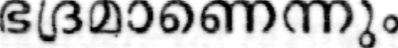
ഭദ്രമാണെന്നും
